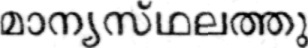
മാന്യസ്ഥലത്തു
